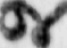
જ
